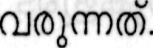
വരുന്നത്.
